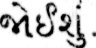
જોઈશું.
